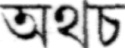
অথচ
